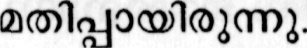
മതിപ്പായിരുന്നു.
